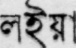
লইয়া
